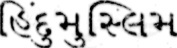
હિંદુમુસ્લિમ
